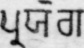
ਪ੍ਰਯੋਗ
